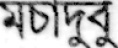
মচাদুবু
